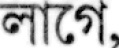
লাগে,
